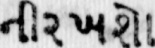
નીરખશો
